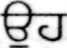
ਉਹ
